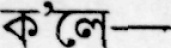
ক'লে-
